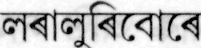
লৰালুৰিবোৰে
